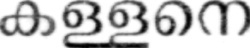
കള്ളനെ
